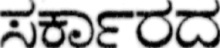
ಸರ್ಕಾರದ
